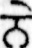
ਨੇ
